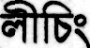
লীচিং
